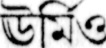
ঊর্মিও
